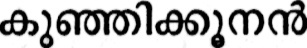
കുഞ്ഞിക്കൂനന്‍
